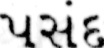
પસંદ
